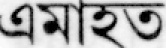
এমাহত
